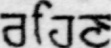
ਰਹਿਣ
